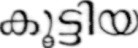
കൂട്ടിയ
